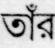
তাঁর
